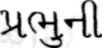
પ્રભુની
